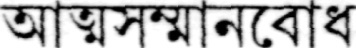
আত্মসম্মানবোধ
